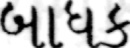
બાધક
